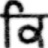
ਕਿ
